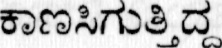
ಕಾಣಸಿಗುತ್ತಿದ್ದ
